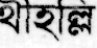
থীহল্লি
